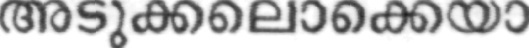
അടുക്കലൊക്കെയാ
